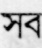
সব
